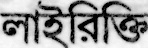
লাইরিক্তি
